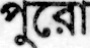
পুরো
